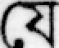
যে
